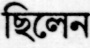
ছিলেন
